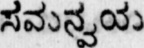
ಸಮನ್ವಯ
